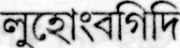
লুহোংবগিদি
